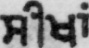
ਸੀਖਾਂ
